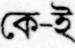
কে-ই
